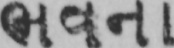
ભવના
